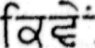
ਕਿਵੇਂ
